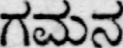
ಗಮನ
